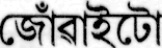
জোঁৱাইটো
